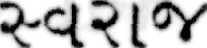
સ્વરાજ
